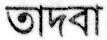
তাদবা
